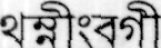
থম্নীংবগী
